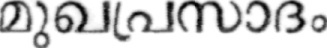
മുഖപ്രസാദം
